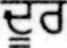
ਦੂਰ
